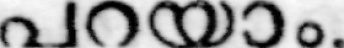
പറയാം.
